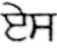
ਏਸ
